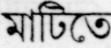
মাটিতে
